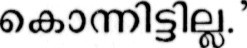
കൊന്നിട്ടില്ല.’
